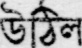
উঠিল
